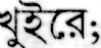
খুইরে;
